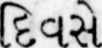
દિવસે
